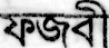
ফজবী
